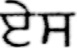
ਏਸ
